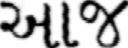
આજ
